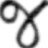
જ
